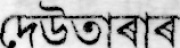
দেউতাৰাৰ
